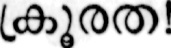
ക്രൂരത!
